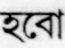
হবো
